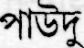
পাউদু
